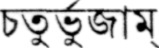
চতুর্ভুজাম্
